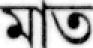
মাত
